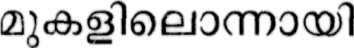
മുകളിലൊന്നായി
